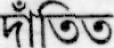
দাঁতিত
